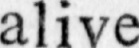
alive
